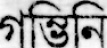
গম্ভিনি
